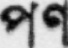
পণ
